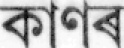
কাণৰ
